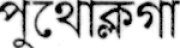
পুথোক্লগা
